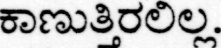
ಕಾಣುತ್ತಿರಲಿಲ್ಲ.
